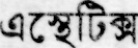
এস্থেটিক্স
